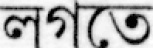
লগতে
